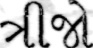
ત્રીજો
